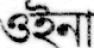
ওইনা
